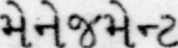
મેનેજમેન્ટ
